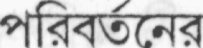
পরিবর্তনের
